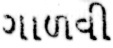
ગાળવી
